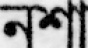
নশা
